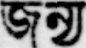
জন্য
